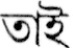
তাই
